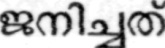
ജനിച്ചത്
